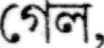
গেল,
